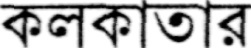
কলকাতার
